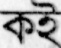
কই
